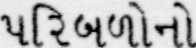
પરિબળોનો
